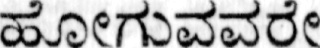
ಹೋಗುವವರೇ
